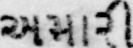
અમારી
